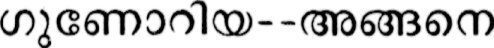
ഗുണോറിയ--അങ്ങനെ
